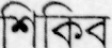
শিকিব
